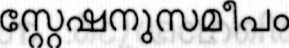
സ്റ്റേഷനുസമീപം
